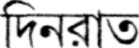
দিনরাত
